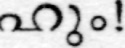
ഹും!
